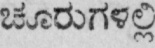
ಚೂರುಗಳಲ್ಲಿ
